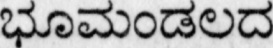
ಭೂಮಂಡಲದ
